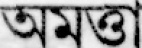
অমত্তা
